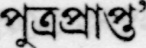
পুত্রপ্রাপ্ত’
